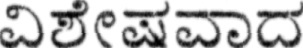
ವಿಶೇಷವಾದ
